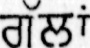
ਗੱਲਾਂ
